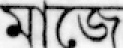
মাজে
